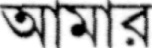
আমার
